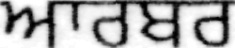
ਆਰਬਰ
